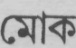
মোক
